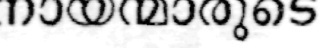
നായന്മാരുടെ
